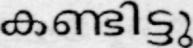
കണ്ടിട്ടു
